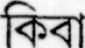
কিবা
